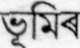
ভূমিৰ
